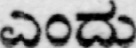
ಎಂದು
